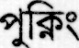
পুক্নিং
